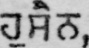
ਹੁਸੈਨ,
